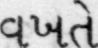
વખતે
